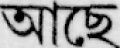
আছে
